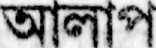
আলাপ
